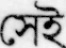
সেই
